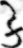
કે
